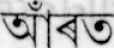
আঁৰত
